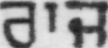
ਰਾਜ
